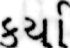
કર્યા
